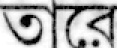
তারে
